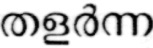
തളര്‍ന്ന
